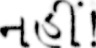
નહીં!
